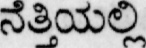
ನೆತ್ತಿಯಲ್ಲಿ
